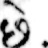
છે.
